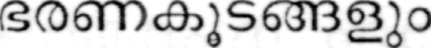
ഭരണകൂടങ്ങളും
